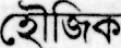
হৌজিক
